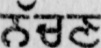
ਨੱਚਣ
